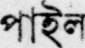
পাইল
